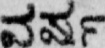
ವರ್ಷ
